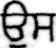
ਉਸ
